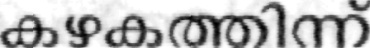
കഴകത്തിന്ന്
